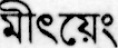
মীৎয়েং
